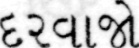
દરવાજો
